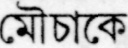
মৌচাকে
